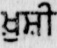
ਖ਼ੁਸ਼ੀ
